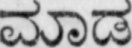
ಮಾಡ
